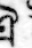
ঐ
